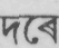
দৰে
